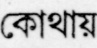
কোথায়
